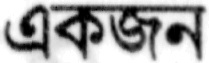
একজন
